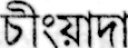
চীংয়াদা
